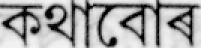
কথাবোৰ
